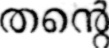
തന്റെ
